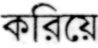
করিয়ে
